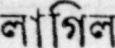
লাগিল
